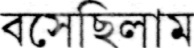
বসেছিলাম
